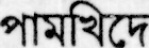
পামখিদে
